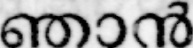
ഞാന്‍
